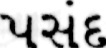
પસંદ
